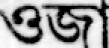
ওজা
